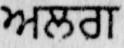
ਅਲਗ
